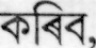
কৰিব,
